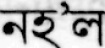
নহ'ল
